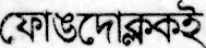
ফোঙদোক্লকই
